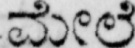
ಮೇಲೆ
